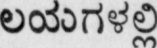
ಲಯಗಳಲ್ಲಿ
